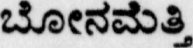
ಬೋನಮೆತ್ತಿ
